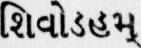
શિવોડહમ્
